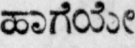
ಹಾಗೆಯೇ
